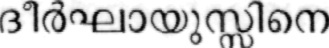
ദീര്‍ഘായുസ്സിനെ
